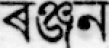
ৰঞ্জন
